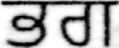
ਭਗ
